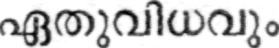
ഏതുവിധവും
